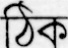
ঠিক
